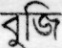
বুজি
